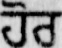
ਹੋਰ
